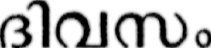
ദിവസം
